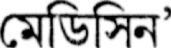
মেডিসিন'
